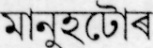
মানুহটোৰ
